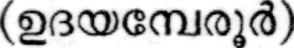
(ഉദയമ്പേരൂര്‍)
